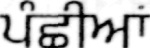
ਪੰਛੀਆਂ
